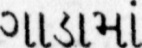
ગાડામાં
